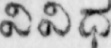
ವಿವಿಧ
